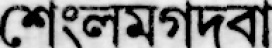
শেংলমগদবা
